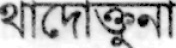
থাদোক্তুনা
